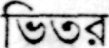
ভিতর
